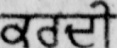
ਕਰਦੀ
